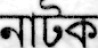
নাটক
